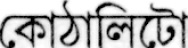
কোঠালিটো
